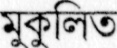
মুকুলিত
